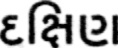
દક્ષિણ
